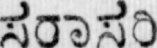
ಸರಾಸರಿ
